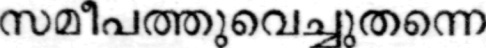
സമീപത്തുവെച്ചുതന്നെ
